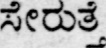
ಸೇರುತ್ತೆ
